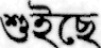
শুইছে
